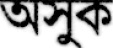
অসুক
